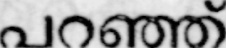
പറഞ്ഞ്
